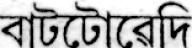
বাটটোৱেদি
